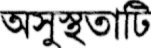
অসুস্থতাটি
